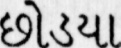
છોડયા
